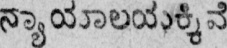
ನ್ಯಾಯಾಲಯಕ್ಕಿವೆ
